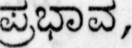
ಪ್ರಭಾವ,
